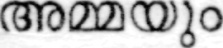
അമ്മയും
